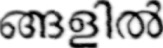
ങ്ങളില്‍
